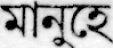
মানুহে
